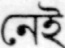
নেই
